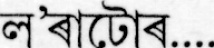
ল'ৰাটোৰ....
